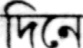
দিনে
